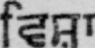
ਵਿਸ਼ਾ
